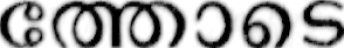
ത്തോടെ
